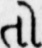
તો
